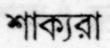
শাক্যরা
